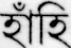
হাঁহি
